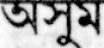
অসুম
